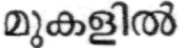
മുകളില്‍
